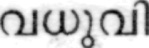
വധുവി
